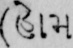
(હોમ
